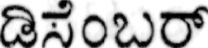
ಡಿಸೆಂಬರ್
